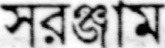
সরঞ্জাম
